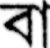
বা
